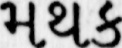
મથક
